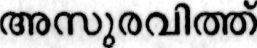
അസുരവിത്ത്
